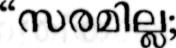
“സരമില്ല;
